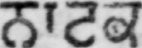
ਨਾਟਕ
